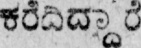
ಕರೆದಿದ್ದಾರೆ.
